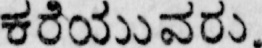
ಕರೆಯುವರು.
